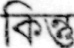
কিন্তু
